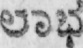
ಲಾಭ
